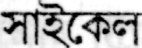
সাইকেল
